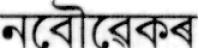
নবৌৱেকৰ
